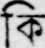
কি
